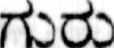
ಗುರು
